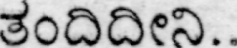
ತಂದಿದೀನಿ..
